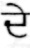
ਦੇ
